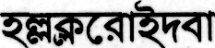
হল্লক্লরোইদবা
